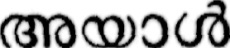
അയാള്‍
